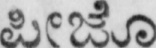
ಪೀಜೋ
